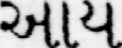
આય
